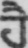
ਹੈ
